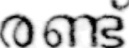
രണ്ട്
